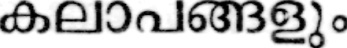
കലാപങ്ങളും
